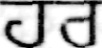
ਹਰ
